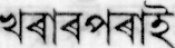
খৰাৰপৰাই
